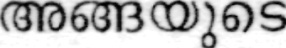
അങ്ങയുടെ
